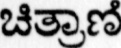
ಚಿತ್ರಾಣಿ
